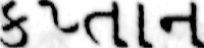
કપ્તાન
